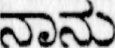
ನಾನು
